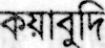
কয়াবুদি
